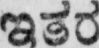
ಇತರ
